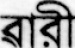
ৱারী
